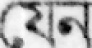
যেন
